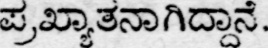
ಪ್ರಖ್ಯಾತನಾಗಿದ್ದಾನೆ.
